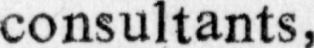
consultants,
